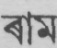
ৰাম
